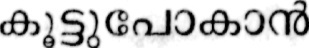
കൂട്ടുപോകാന്‍
